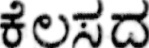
ಕೆಲಸದ
